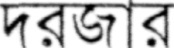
দরজার
